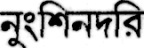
নুংশিনদরি
